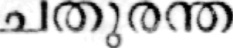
ചതുരന്ത
